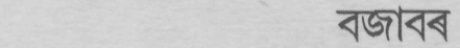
বজাবৰ
